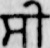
ਸੀ
